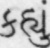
કહ્યું
